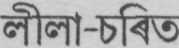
লীলা-চৰিত
